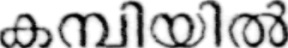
കമ്പിയില്‍
